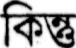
কিন্তু
